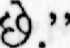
છે."
